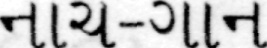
નાચ-ગાન
